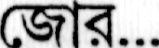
জোর...
